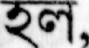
হল,
